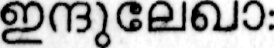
ഇന്ദുലേഖാ:
